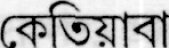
কেতিয়াবা
